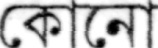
কোনো
